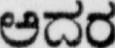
ಅದರ
